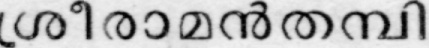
ശ്രീരാമന്‍തമ്പി
